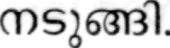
നടുങ്ങി.
